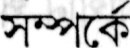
সম্পর্কে
